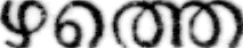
ഴത്തെ
